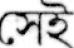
সেই
